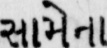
સામેના
